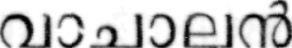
വാചാലന്‍
